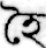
হৈ
